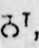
ਨਾ,
